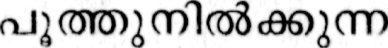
പൂത്തുനില്‍ക്കുന്ന
